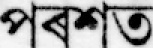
পৰশত
